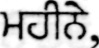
ਮਹੀਨੇ,
